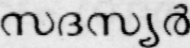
സദസ്യര്‍
